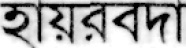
হায়রবদা
